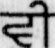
ਵੀ
